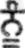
ਨੂੰ
